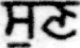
ਸੁਣ
